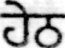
ਹੇਠ
